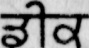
ਡੀਕ
